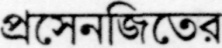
প্রসেনজিতের
